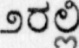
೨ರಲ್ಲಿ
